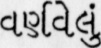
વર્ણવેલું
